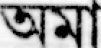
অমা
